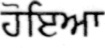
ਹੋਇਆ
